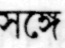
সঙ্গে
